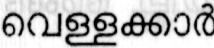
വെള്ളക്കാര്‍
